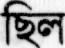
ছিল
